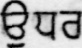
ਉਧਰ
